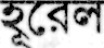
দিঃ
